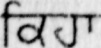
ਕਿਹਾ
